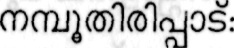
നമ്പൂതിരിപ്പാട്:
